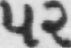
પર
